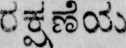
ರಕ್ಷಣೆಯ
